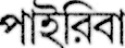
পাইরিবা
